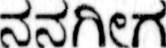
ನನಗೀಗ
